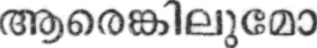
ആരെങ്കിലുമോ
